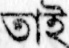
তাই
